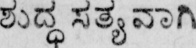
ಶುದ್ಧಸತ್ಯವಾಗಿ
